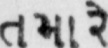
તમારે
